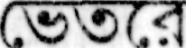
ভেতরে
